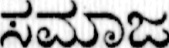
ಸಮಾಜ
